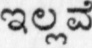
ಇಲ್ಲವೆ
